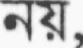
নয়,
